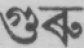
গুৰু
